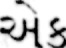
એક
